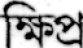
ক্ষিপ্র
